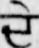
ਦੇ
